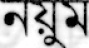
নয়ুম
